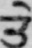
ਤੇ
